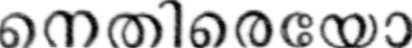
നെതിരെയോ
